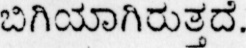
ಬಿಗಿಯಾಗಿರುತ್ತದೆ.
